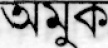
অমুক
